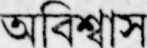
অবিশ্বাস
